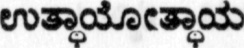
ಉತ್ಥಾಯೋತ್ಥಾಯ
